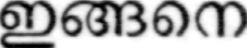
ഇങ്ങനെ
